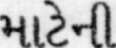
માટેની
